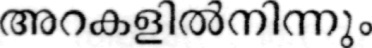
അറകളില്‍നിന്നും
